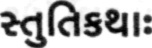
સ્તુતિકથાઃ
